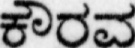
ಕೌರವ
